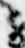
કે
